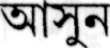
আসুন
